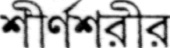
শীর্ণশরীর
